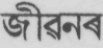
জীৱনৰ
